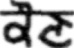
ਕੌਣ
